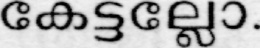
കേട്ടല്ലോ.
